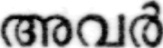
അവര്‍
